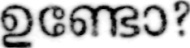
ഉണ്ടോ?
